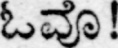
ಓವೊ!
